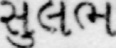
સુલભ
